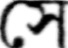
সে
